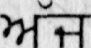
ਅੱਜ
